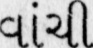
વાંચી
